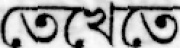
তেখেতে
